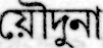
য়ৌদুনা
